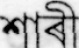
শাৰী
